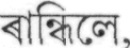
ৰান্ধিলে,
